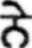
ਨੇ
